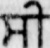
ਸੀ
